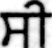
ਸੀ
